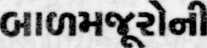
બાળમજૂરોની
